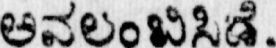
ಅವಲಂಬಿಸಿದೆ.
